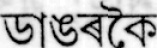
ডাঙৰকৈ
